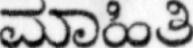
ಮಾಹಿತಿ
